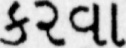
કરવા
